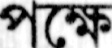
পক্ষে
